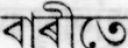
বাৰীতে
